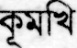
কূমখি
